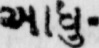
આધુ-
